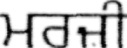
ਮਰਜ਼ੀ
